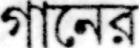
গানের
